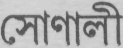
সোণালী
